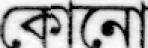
কোনো
